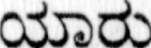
ಯಾರು
